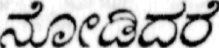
ನೋಡಿದರೆ
